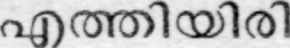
എത്തിയിരി
